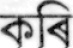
কৰি
